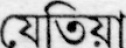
যেতিয়া
